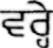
ਵਰ੍ਹੇ
